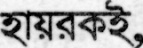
হায়রকই,
